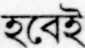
হবেই
